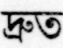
দ্রুত
